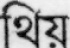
থিয়
